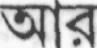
আর
